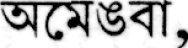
অমেঙবা,
